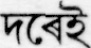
দৰেই
